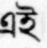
এই
